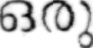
ഒരു
